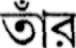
তাঁর
